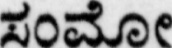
ಸಂಮೋ
